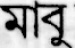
মাবু
